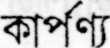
কার্পণ্য
